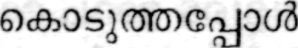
കൊടുത്തപ്പോള്‍
